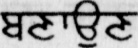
ਬਣਾਉਣ
